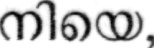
നിയെ,
